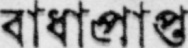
বাধাপ্রাপ্ত
